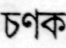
চণক
